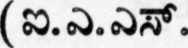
(ಐ.ಎ.ಎಸ್.
